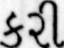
કરી
